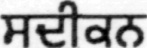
ਸਦੀਕਨ
